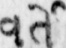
વર્તે
